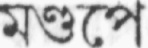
মণ্ডপে
